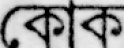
কোক
